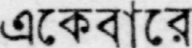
একেবারে
